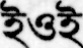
ইওই
